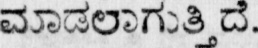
ಮಾಡಲಾಗುತ್ತಿದೆ.
